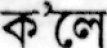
ক'লে
